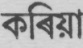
কৰিয়া
